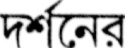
দর্শনের
